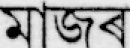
মাজৰ
